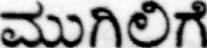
ಮುಗಿಲಿಗೆ
